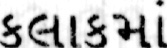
કલાકમાં
